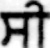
ਸੀ
